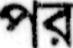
পর
